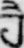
ਹੈ
